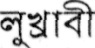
লুখ্রাবী
